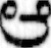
ಆ
